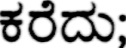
ಕರೆದು;
